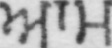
ਆਮ
